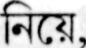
নিয়ে,
